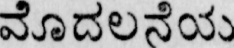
ಮೊದಲನೆಯ
